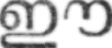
ഈ
